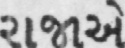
રાજાએ
